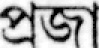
প্রজা
